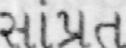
સાંપ્રત
